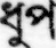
ধুপ
